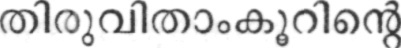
തിരുവിതാംകൂറിന്റെ
